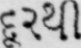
દુરથી
